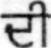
ਦੀ
